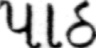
પાઠ
